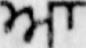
ਆ
